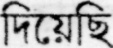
দিয়েছি
